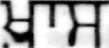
ਖ਼ਾਸ
